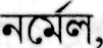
নর্মেল,
